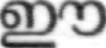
ഈ
